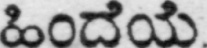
ಹಿಂದೆಯೆ.
